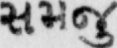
સમજુ
